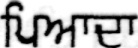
ਪਿਆਦਾ
